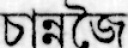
চান্নজৈ
